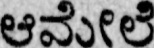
ಆಮೇಲೆ
